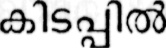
കിടപ്പില്‍
